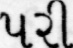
પરી
